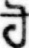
ਹੋ
